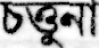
চত্তুনা
